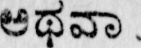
ಅಥವಾ.
